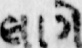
લાગે
